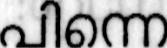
പിന്നെ
